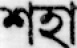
শহা
